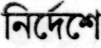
নির্দেশে
